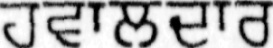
ਹਵਾਲਦਾਰ
